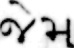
જેમ
